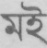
মই
